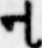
ન
